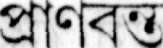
প্রাণবন্ত
